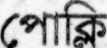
পোক্লি
